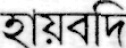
হায়বদি
